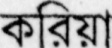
করিয়া
